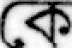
কে
